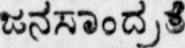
ಜನಸಾಂದ್ರತೆ
